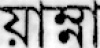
য়াম্না
